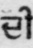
ਦੀ
